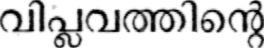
വിപ്ലവത്തിന്റെ
